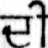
ਦੀ
